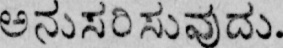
ಅನುಸರಿಸುವುದು.
